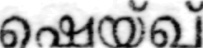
ഷെയ്ഖ്
